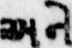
અને
